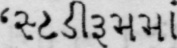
'સ્ટીડીરૂમમાં
